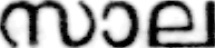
സാല
